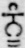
ਨੂੰ
